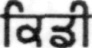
ਕਿਡੀ
